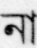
না
